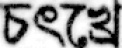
চৎখ্রে
